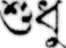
শুধু
